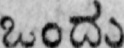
ಒಂದು
